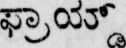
ಫ್ರಾಯ್ಡ್
